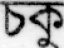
চকু
